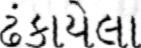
ઢંકાયેલા
